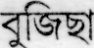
বুজিছা
